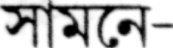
সামনে-
